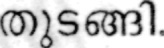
തുടങ്ങി.
